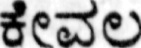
ಕೇವಲ
